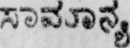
ಸಾಮಾನ್ಯ
